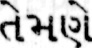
તેમણે
